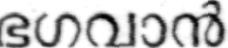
ഭഗവാന്‍
